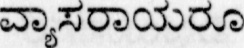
ವ್ಯಾಸರಾಯರೂ
